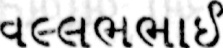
વલ્લભભાઈ
